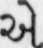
એ
